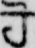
ਹੋ
